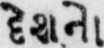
દેશનો
